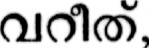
വറീത്,
